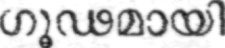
ഗൂഢമായി
